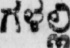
ಗಳಲ್ಲಿ
